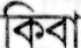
কিবা
